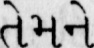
તેમને
